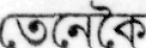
তেনেকৈ
